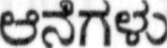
ಆನೆಗಳು
